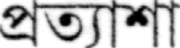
প্রত্যাশা
